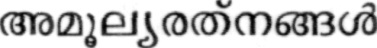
അമൂല്യരത്നങ്ങള്‍
